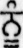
ਨੂੰ
